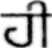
ਹੀ
